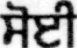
ਸੋਈ
